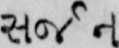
સર્જન
